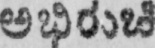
ಅಭಿರುಚಿ
